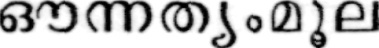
ഔന്നത്യംമൂല
